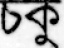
চকু
